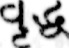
વૃદ્ધ
